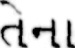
તેના
